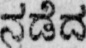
ನಡೆದ
